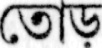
তোড়
